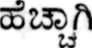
ಹೆಚ್ಚಾಗಿ
